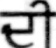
ਦੀ
